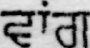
ਵਾਂਗ
